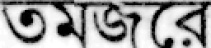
তমজরে
